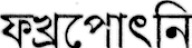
ফখ্রপোৎনি
